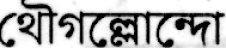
থৌগল্লোন্দো
